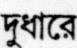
দুধারে
